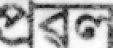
প্ৰৱল
